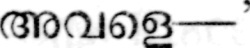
അവളെ-’
